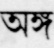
অঙ্গ
